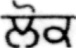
ਲੋਕ
